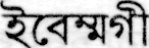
ইবেম্মগী
